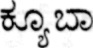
ಕ್ಯೂಬಾ
